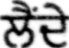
ਲੈਂਦੇ
